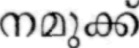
നമുക്ക്
